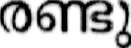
രണ്ടു
